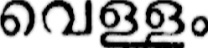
വെള്ളം
